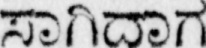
ಸಾಗಿದಾಗ
